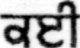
ਕਈ
